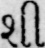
શી
